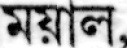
ময়াল,
